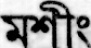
মশীং
